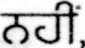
ਨਹੀਂ,
